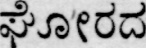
ಘೋರದ
